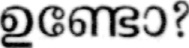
ഉണ്ടോ?
